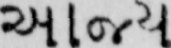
આજ્ય
